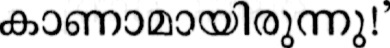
കാണാമായിരുന്നു!'
